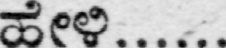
ಹೇಳಿ......
